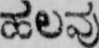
ಹಲವು
